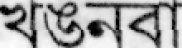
খঙনবা
